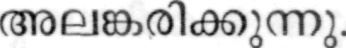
അലങ്കരിക്കുന്നു.
